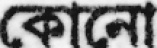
কোনো
